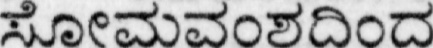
ಸೋಮವಂಶದಿಂದ
